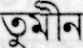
তুমীন
